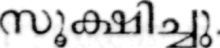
സൂക്ഷിച്ചു.
